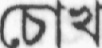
চোখ
